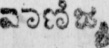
ವಾಣಿಜ್ಯ
